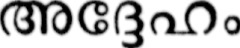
അദ്ദേഹം
